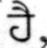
ਹੈ,
